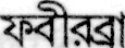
ফবীরব্রা
